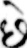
છે
